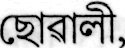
ছোৱালী,
